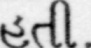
હતી.
